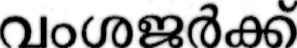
വംശജര്‍ക്ക്
